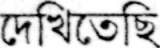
দেখিতেছি
